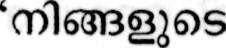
‘നിങ്ങളുടെ
